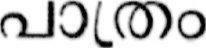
പാത്രം
